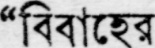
‘‘বিবাহের
